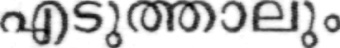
എടുത്താലും
